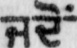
ਜਦੋਂ
